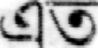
এত
